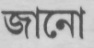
জানো
